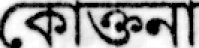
কোক্তনা
